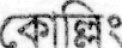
কোল্লিং
